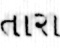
તારા
